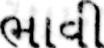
ભાવી
